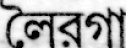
লৈরগা
